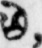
છે,
